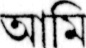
আমি
